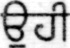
ਉਹੀ
